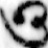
ও
